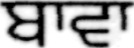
ਬਾਵਾ
